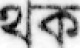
থক
